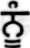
ਨੂੰ
